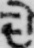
ਦੇ
